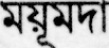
ময়ুমদা
